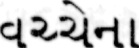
વચ્ચેના
